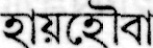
হায়হৌবা
